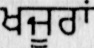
ਖਜੂਰਾਂ
